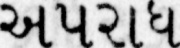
અપરાધ
